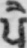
ਪੈ
